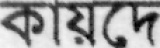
কায়দে
